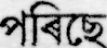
পৰিছে
